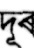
দূৰ
